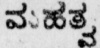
ಮಹತ್ವ
